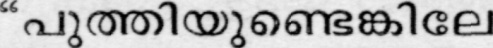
"പുത്തിയുണ്ടെങ്കിലേ
